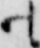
ન
